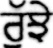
ਰੁੱਝੇ
